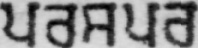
ਪਰਸਪਰ
